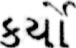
કર્યો
